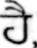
ਹੈ,
